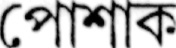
পোশাক
